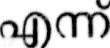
എന്ന്
